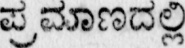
ಪ್ರಮಾಣದಲ್ಲಿ
